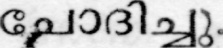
ചോദിച്ചു.
